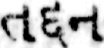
તદ્દન
